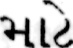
માટે
